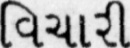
વિચારી
